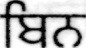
ਬਿਨ
